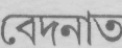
বেদনাত
